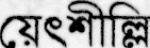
য়েৎশীল্লি
